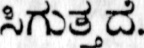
ಸಿಗುತ್ತದೆ.
